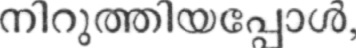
നിറുത്തിയപ്പോള്‍,
